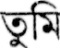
তুমি
